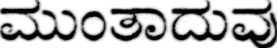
ಮುಂತಾದುವು
